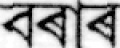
বৰাৰ
